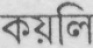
কয়লি
